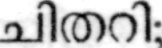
ചിതറി;
